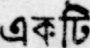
একটি
